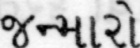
જન્મારો
